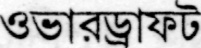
ওভারড্রাফট
